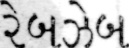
રેબઝેબ
